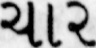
ચાર
